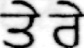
ਤੇਰੇ
